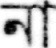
না
